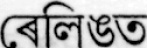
ৰেলিঙত
